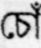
চোঁ
